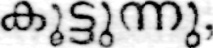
കൂട്ടുന്നു,
